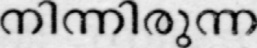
നിന്നിരുന്ന
